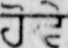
ਹੋਵੇ
